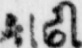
કાઢી
